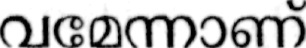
വമേന്നാണ്
